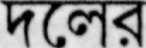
দলের
